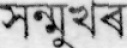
সন্মুখৰ
